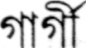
গার্গী
